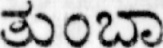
ತುಂಬಾ
